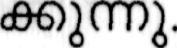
ക്കുന്നു.
